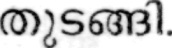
തുടങ്ങി.
